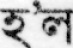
হ'ল
